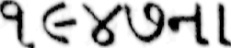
૧૯૪૭ના
